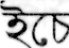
ইচে
